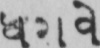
ધરાવે
